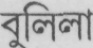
বুলিলা
